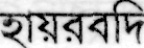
হায়রবদি
